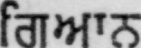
ਗਿਆਨ
